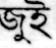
জুই
